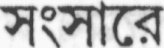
সংসারে
